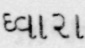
ધ્વારા
